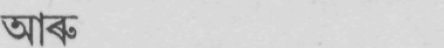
আৰু
